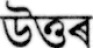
উত্তৰ
